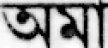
অমা
